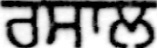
ਰਸਾਲ
